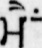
ਮੈਂ
